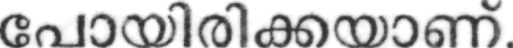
പോയിരിക്കയാണ്.
